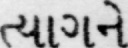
ત્યાગને
